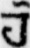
ਹੋ
